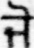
ਜੋ
